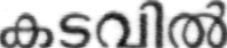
കടവില്‍
